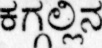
ಕಗ್ಗಲ್ಲಿನ
